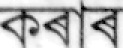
কৰাৰ
